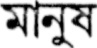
মানুষ
